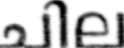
ചില
